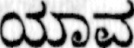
ಯಾವ
